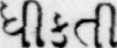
ધીકતી
